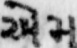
એમ
